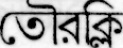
তৌরক্লি
